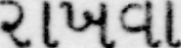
રાખવા
